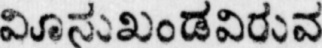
ಮೀನುಖಂಡವಿರುವ
